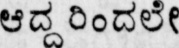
ಆದ್ದರಿಂದಲೇ
